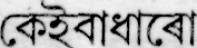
কেইবাধাৰো
